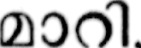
മാറി.
